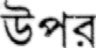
উপর
